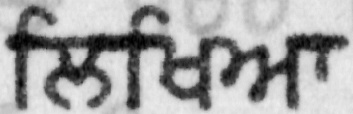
ਲਿਖਿਆ
